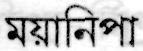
ময়ানিপা
